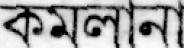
কমলাদা
